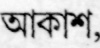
আকাশ,
